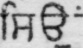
ਸਿਉਂ
